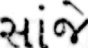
સાંજે
